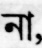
না,
